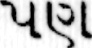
પણ
